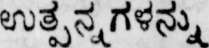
ಉತ್ಪನ್ನಗಳನ್ನು
